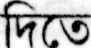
দিতে
